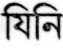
যিনি
